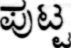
ಪುಟ್ಟ
